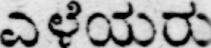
ಎಳೆಯರು
